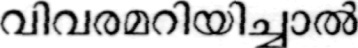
വിവരമറിയിച്ചാല്‍
